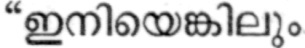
“ഇനിയെങ്കിലും
